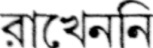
রাখেননি
